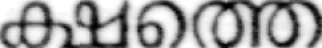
ക്ഷത്തെ
